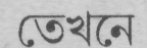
তেখনে
